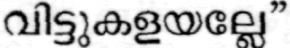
വിട്ടുകളയല്ലേ”
